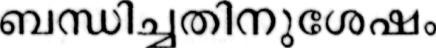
ബന്ധിച്ചതിനുശേഷം
